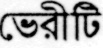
ভেরীটি
